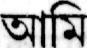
আমি
